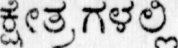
ಕ್ಷೇತ್ರಗಳಲ್ಲಿ
